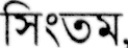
সিংতম,
